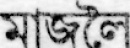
মাজলৈ
